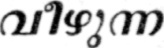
വീഴുന്ന
